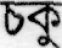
চকু
